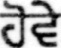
ਹੋਵੇ
